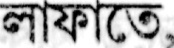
লাফাতে,
